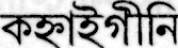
কহ্নাইগীনি
